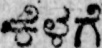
ಕೆಳಗೆ
